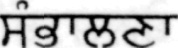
ਸੰਭਾਲਣਾ
